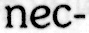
nec-
